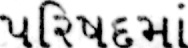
પરિષદમાં
